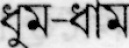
ধুম-ধাম
